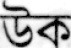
উক
